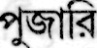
পুজারি
